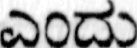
ಎಂದು
